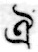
ঐ
